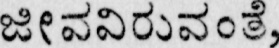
ಜೀವವಿರುವಂತೆ,
